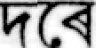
দৰে
